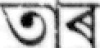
তাৰ
